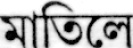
মাতিলে
